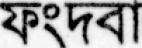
ফংদবা
